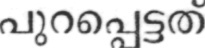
പുറപ്പെട്ടത്
